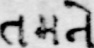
તમને
